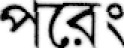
পরেং
